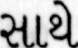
સાથે
